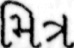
મિત્ર
